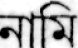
নামি
